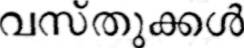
വസ്തുക്കള്‍
